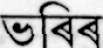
ভৰিৰ
